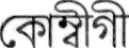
কোম্বীগী
